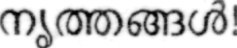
നൃത്തങ്ങള്‍!
